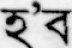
হ'ব
